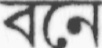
বনে
